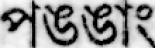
পঙঙাং
